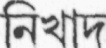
নিখাদ
